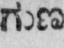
ಗುಣ
